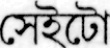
সেইটো
